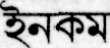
ইনকম
